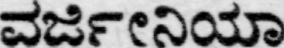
ವರ್ಜೀನಿಯಾ
